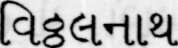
વિઠ્ઠલનાથ
